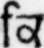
ਕਿ
